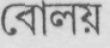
বোলয়
